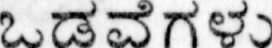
ಒಡವೆಗಳು
